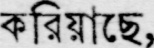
করিয়াছে,
